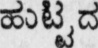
ಹುಟ್ಟಿದ
